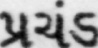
પ્રચંડ
